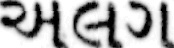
અલગ
